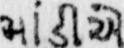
માંડીએ
